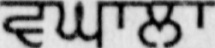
ਵਘਾਲਾ
